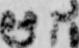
ಆಗ
